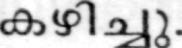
കഴിച്ചു.
